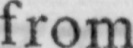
from
